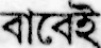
বাবেই
